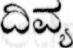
ದಿವ್ಯ
